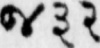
જરૂર
